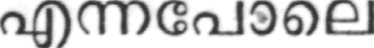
എന്നപോലെ
